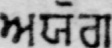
ਅਯੋਗ
